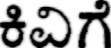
ಕಿವಿಗೆ
